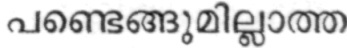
പണ്ടെങ്ങുമില്ലാത്ത
